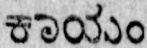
ಕಾಯಂ
